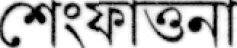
শেংফাত্তনা
